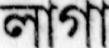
লাগা
